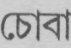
চোবা
